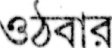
ওঠবার
